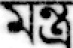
মন্ত্র
